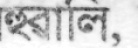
হুৱালি,
